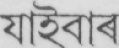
যাইবাৰ
